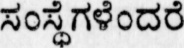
ಸಂಸ್ಥೆಗಳೆಂದರೆ
